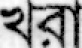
খরা
